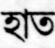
হাত
